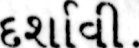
દર્શાવી.
